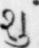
શું
